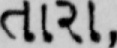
તારા,
